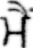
ਮੈਂ
